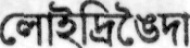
লোইদ্রিঙৈদা
